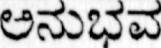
ಅನುಭವ
